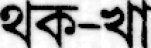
থক-খা
